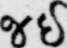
જઈ
